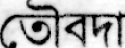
তৌবদা
